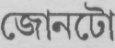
জোনটো
